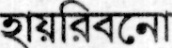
হায়রিবনো
